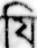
যি
